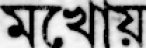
মখোয়
